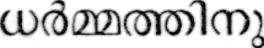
ധര്‍മ്മത്തിനു
